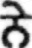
ਨੇ
